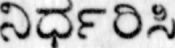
ನಿರ್ಧರಿಸಿ
